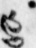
હું
